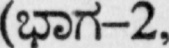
(ಭಾಗ-2,
